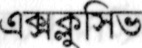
এক্সক্লুসিভ
